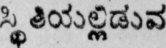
ಸ್ಥಿತಿಯಲ್ಲಿಡುವ
